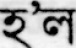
হ'ল
